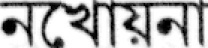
নখোয়না
